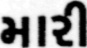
મારી
